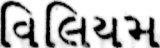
વિલિયમ
